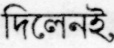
দিলেনই,
